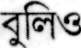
বুলিও
